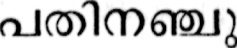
പതിനഞ്ചു
